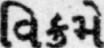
વિક્રમે
